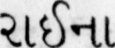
રાઈના
